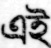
এই
